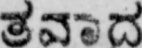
ತವಾದ
